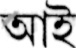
আই
